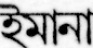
ইমানা
